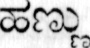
ಹಣ್ಣು
